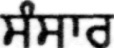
ਸੰਸਾਰ
